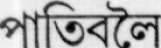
পাতিবলৈ
